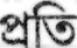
প্রতি
